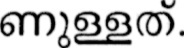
ണുള്ളത്.
